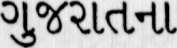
ગુજરાતના
